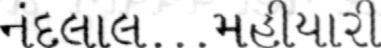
નંદલાલ...મહીયારી
